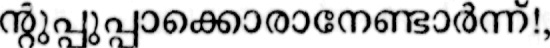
ന്റുപ്പുപ്പാക്കൊരാനേണ്ടാര്‍ന്ന്!,
